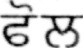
ਫੋਲ
